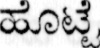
ಹೊಟ್ಟೆ
